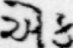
એક
